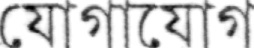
যোগাযোগ
